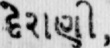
દેરાણી,
